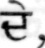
ਦੇ,
